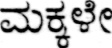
ಮಕ್ಕಳೇ
